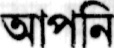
আপনি
